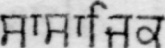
ਸਾਮਾਜਿਕ
